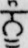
ਨੂੰ
